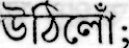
উঠিলোঁ;
